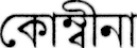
কোম্বীনা
